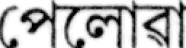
পেলোৱা
